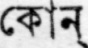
কোন্
